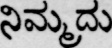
ನಿಮ್ಮದು
